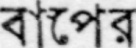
বাপের
